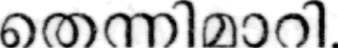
തെന്നിമാറി.
